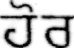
ਹੋਰ
